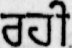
ਰਹੀ
